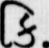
કિ.
